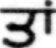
ਤਾਂ
